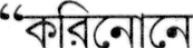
“করিনোনে
